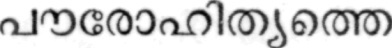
പൌരോഹിത്യത്തെ
